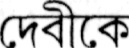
দেবীকে
